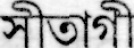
সীতাগী
